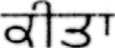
ਕੀਤਾ
